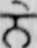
ਨੇ
